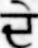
ਦੇ
